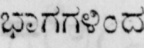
ಭಾಗಗಳಿಂದ
